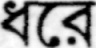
ধরে
